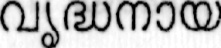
വൃദ്ധനായ
